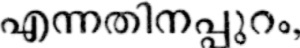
എന്നതിനപ്പുറം,
